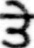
ਤੇ
